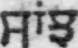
ਸਾਂਝ
